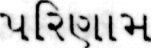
પરિણામ
